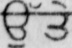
ਉੱਤੇ
